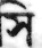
সি
